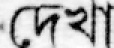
দেখা
